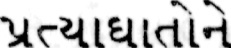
પ્રત્યાઘાતોને
